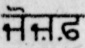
ਜੋਜ਼ਫ਼
